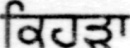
ਕਿਹੜਾ
